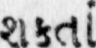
શકતાં
